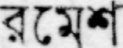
রমেশ
